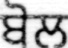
ਬੋਲ
